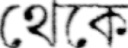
থেকে
